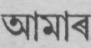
আমাৰ
